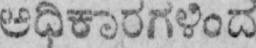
ಅಧಿಕಾರಗಳಿಂದ
